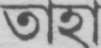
তাহা
